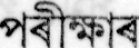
পৰীক্ষাৰ
